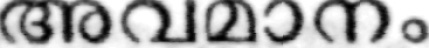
അവമാനം
